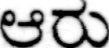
ಆರು
